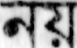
নয়
